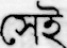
সেই
